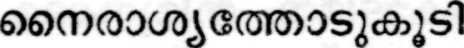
നൈരാശ്യത്തോടുകൂടി
